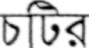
চটির
